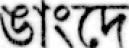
ঙাংদে
